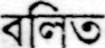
বলিত
